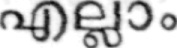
എല്ലാം
